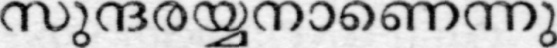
സുന്ദരയ്യനാണെന്നു
